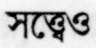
সত্ত্বেও
